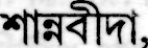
শান্নবীদা,
